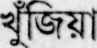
খুঁজিয়া
